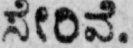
ಸೇರಿವೆ.
